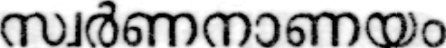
സ്വര്‍ണനാണയം
